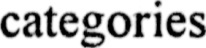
categories
